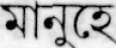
মানুহে
